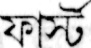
ফার্স্ট
